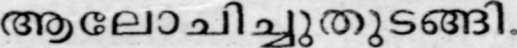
ആലോചിച്ചുതുടങ്ങി.
